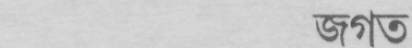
জগত
